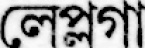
লেপ্লগা
